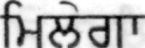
ਮਿਲੇਗਾ
